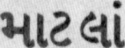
માટલાં
